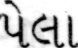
પેલા
